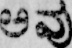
ಅವು
